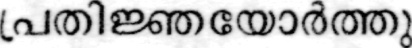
പ്രതിജ്ഞയോര്‍ത്തു
